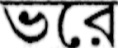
ভরে
